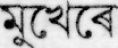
মুখেৰে
